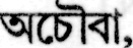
অচৌবা,
